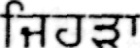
ਜਿਹੜਾ
